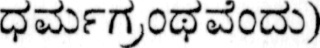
ಧರ್ಮಗ್ರಂಥವೆಂದು)
